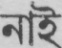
নাই
